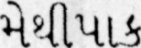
મેથીપાક
